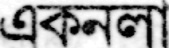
একনলা
